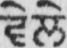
ਵੇਲੇ
